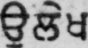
ਉਲੇਖ
